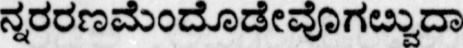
ನ್ನರರಣಮೆಂದೊಡೇವೊಗೞ್ವುದಾ
